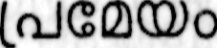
പ്രമേയം
